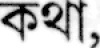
কথা,
